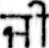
ਜੀ
